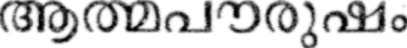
ആത്മപൌരുഷം
